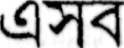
এসব
